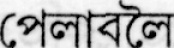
পেলাবলৈ
